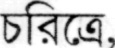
চরিত্রে,
